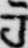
ਹੋ
